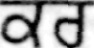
ਕਰ
